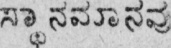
ಸ್ಥಾನಮಾನವು
